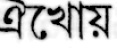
ঐখোয়
